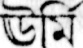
ঊর্মি
